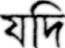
যদি
